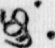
છું.
